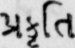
પ્રકૃતિ
